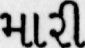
મારી
